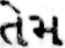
તેમ
